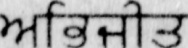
ਅਭਿਜੀਤ
